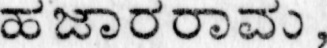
ಹಜಾರರಾಮ,
